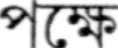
পক্ষে
